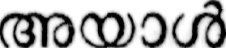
അയാള്‍
